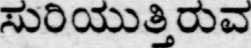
ಸುರಿಯುತ್ತಿರುವ
